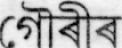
গৌৰীৰ
